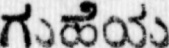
ಗುಹೆಯ
